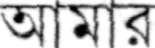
আমার
